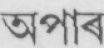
অপাৰ
